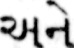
અને
